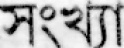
সংখ্যা
